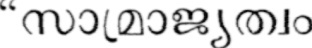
"സാമ്രാജ്യത്വം
